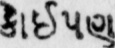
કોઈપણ
